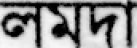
লমদা
